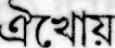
ঐখোয়
